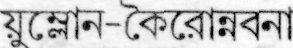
য়ুম্লোন-কৈরোন্নবনা
